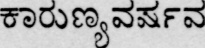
ಕಾರುಣ್ಯವರ್ಷವ
